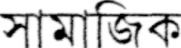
সামাজিক
